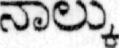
ನಾಲ್ಕು
